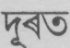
দূৰত
